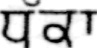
ਧੱਕਾ
